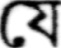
যে
